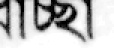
বাচ্ছা
